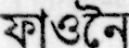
ফাওনৈ
